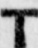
T
